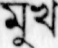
মুখ
